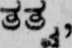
ತತ್ವ,
